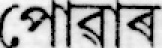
পোৱাৰ
